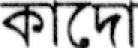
কাদো
